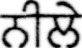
ਨੀਲੇ
